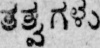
ತತ್ವಗಳು
